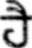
ਹੈ
